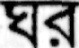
ঘর
